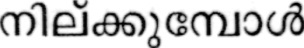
നില്ക്കുമ്പോള്‍
